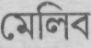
মেলিব
